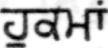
ਹੁਕਮਾਂ
